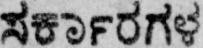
ಸರ್ಕಾರಗಳ
